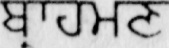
ਬ੍ਰਾਹਮਣ
